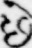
છે
